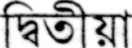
দ্বিতীয়া
